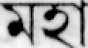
মহা
